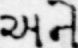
અને
